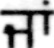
ਜਾਂ
